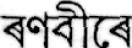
ৰণবীৰে
